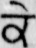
ਕੇ
